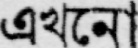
এখনো
